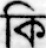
কি
